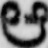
ಆ
